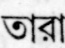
তারা
